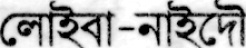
লোইবা-নাইদৌ
